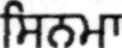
ਸਿਨਮਾ
